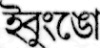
ইবুংঙো
